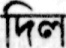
দিল
